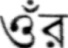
ওঁর
